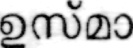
ഉസ്മാ
